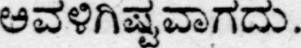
ಅವಳಿಗಿಷ್ಟವಾಗದು.
